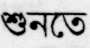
শুনতে
